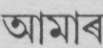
আমাৰ
